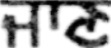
ਜਾਣ
